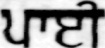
ਪਾਈ
